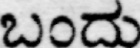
ಬ೦ದು
